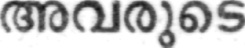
അവരുടെ
